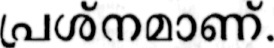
പ്രശ്നമാണ്.
